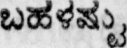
ಬಹಳಷ್ಟು
